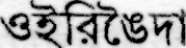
ওইরিঙৈদা
